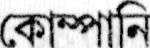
কোম্পানি
